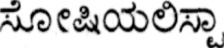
ಸೋಷಿಯಲಿಸ್ಟಾ
